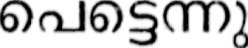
പെട്ടെന്നു
